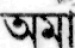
অমা
